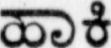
ಹಾಕಿ
